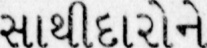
સાથીદારોને
